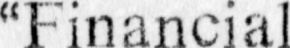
"Financial
